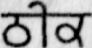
ਠੀਕ
